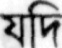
যদি
